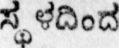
ಸ್ಥಳದಿಂದ
